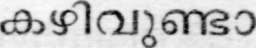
കഴിവുണ്ടാ
